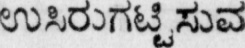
ಉಸಿರುಗಟ್ಟಿಸುವ
